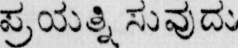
ಪ್ರಯತ್ನಿಸುವುದು
